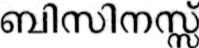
ബിസിനസ്സ്
